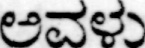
ಅವಳು
